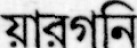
য়ারগনি
